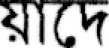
য়াদে
